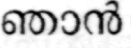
ഞാന്‍
